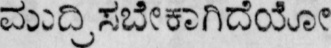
ಮುದ್ರಿಸಬೇಕಾಗಿದೆಯೋ
